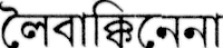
লৈবাক্কিনেনা
